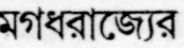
মগধরাজ্যের
